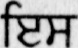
ਇਸ
